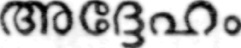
അദ്ദേഹം
